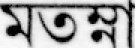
মতম্না
